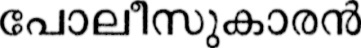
പോലീസുകാരന്‍
